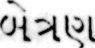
બેત્રણ
